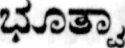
ಭೂತ್ವಾ
